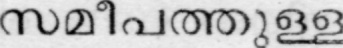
സമീപത്തുള്ള
